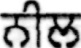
ਨੀਲ
